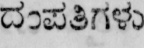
ದಂಪತಿಗಳು
